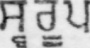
ਸ੍ਵਰੂਪ
